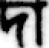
দা
